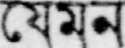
যেমন
